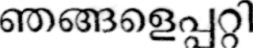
ഞങ്ങളെപ്പറ്റി
